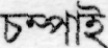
চম্পাই
